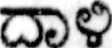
ದಾಳಿ
